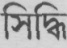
সিদ্ধি
